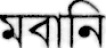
মবানি
